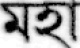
মহা
